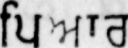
ਪਿਆਰ
